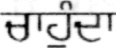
ਚਾਹੁੰਦਾ
